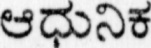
ಆಧುನಿಕ
